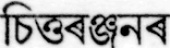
চিত্তৰঞ্জনৰ
